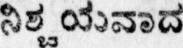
ನಿಶ್ಚಯವಾದ
